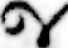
જ
